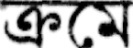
ক্রমে
